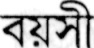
বয়সী
